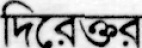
দিরেক্তর
